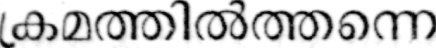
ക്രമത്തില്‍ത്തന്നെ
